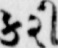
કરી
